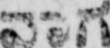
ವಾಗ
